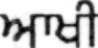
ਆਖੀ
